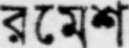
রমেশ
